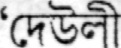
‘দেউলী
